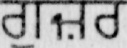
ਗੁਜ਼ਰ
